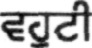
ਵਹੁਟੀ
